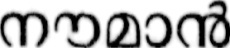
നൌമാന്‍
